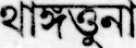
থাঙ্গত্তুনা
